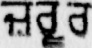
ਜ਼ਰੂਰ
